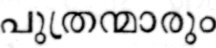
പുത്രന്മാരും
